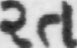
રત
